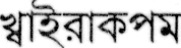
খ্বাইরাকপম
